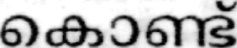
കൊണ്ട്
